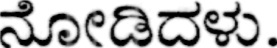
ನೋಡಿದಳು.
